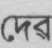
দেৱ
